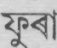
ফুৰা
